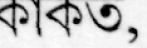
কাকত,
